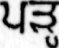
ਪੜ੍ਹ
